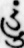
હું
